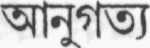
আনুগত্য
